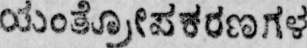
ಯಂತ್ರೋಪಕರಣಗಳ
